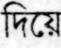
দিয়ে
